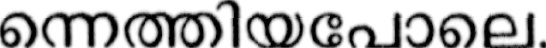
ന്നെത്തിയപോലെ.
